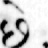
છે.
